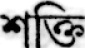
শক্তি
